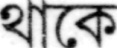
থাকে
